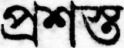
প্রশস্ত
